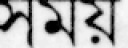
সময়
